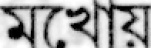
মখোয়
